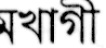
মখাগী
